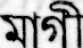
মাগী
